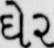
ઘેર
